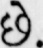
છે.
